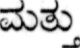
ಮತ್ತು
